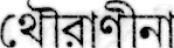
থৌরাণীনা
